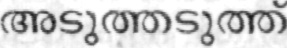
അടുത്തടുത്ത്
